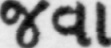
જવા
